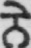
ਨੇ
